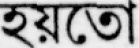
হয়তো
